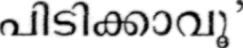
പിടിക്കാവൂ'
